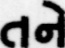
તને
